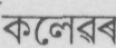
কলেৱৰ
